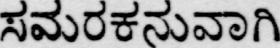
ಸಮರಕನುವಾಗಿ
